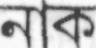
নাক
